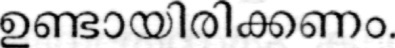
ഉണ്ടായിരിക്കണം.
